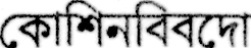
কোশিনবিবদো
